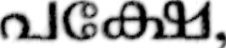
പക്ഷേ,
